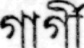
গার্গী
